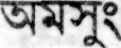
অমসুং
